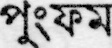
পুংফম
